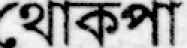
থোকপা
